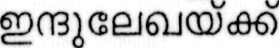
ഇന്ദുലേഖയ്ക്ക്
